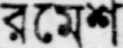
রমেশ
